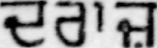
ਦਰਾਜ਼
